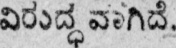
ವಿರುದ್ಧವಾಗಿದೆ.
